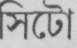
সিটো
